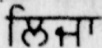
ਲਿਜਾ
